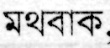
মথবাক,
